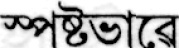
স্পষ্টভাৱে
